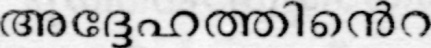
അദ്ദേഹത്തിന്റെ
